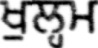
ਖੁਲ੍ਹਮ
